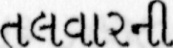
તલવારની
